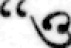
“ও
